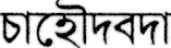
চাহৌদবদা
